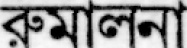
রুমালনা
